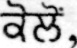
ਕੋਲੋਂ,
